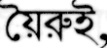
য়ৈরুই,
